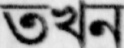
তখন
